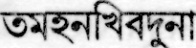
তমহনখিবদুনা
